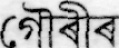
গৌৰীৰ
